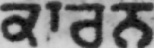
ਕਾਰਨ
